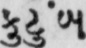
કુટુંબ
